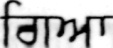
ਗਿਆ
